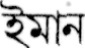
ইমান
